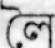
লৈ
